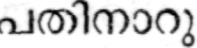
പതിനാറു
